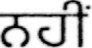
ਨਹੀਂ
